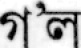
গ'ল
